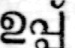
ഉപ്പ്
